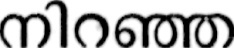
നിറഞ്ഞ
